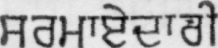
ਸਰਮਾਏਦਾਰੀ
